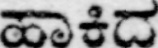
ಹಾಕಿದ
